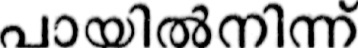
പായില്‍നിന്ന്
